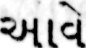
આવે
